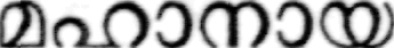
മഹാനായ
